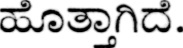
ಹೊತ್ತಾಗಿದೆ.
